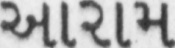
આરામ
